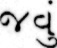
જવું
